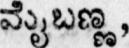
ಮೈಬಣ್ಣ,
